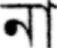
না
